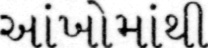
આંખોમાંથી
